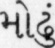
મોઢું
